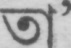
তা'
